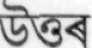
উত্তৰ
